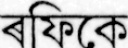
ৰফিকে
